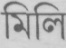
মিলি
